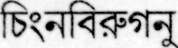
চিংনবিরুগনু
